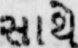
સાથે
